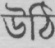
উঠি
